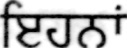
ਇਹਨਾਂ
